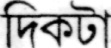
দিকটা
